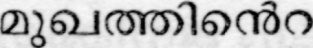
മുഖത്തിന്റെ
